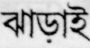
ঝাড়াই
